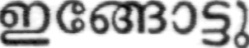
ഇങ്ങോട്ടു
